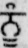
ਨੂੰ
